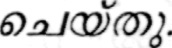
ചെയ്തു.
